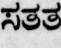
ಸತತ
